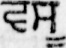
ਵਸੂ
